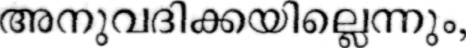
അനുവദിക്കയില്ലെന്നും,
